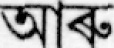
আৰু
